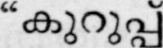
"കുറുപ്പ്
